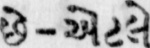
છે-એટલે
